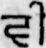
ਵੀ
